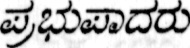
ಪ್ರಭುಪಾದರು
